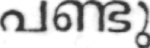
പണ്ടു
